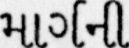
માર્ગની
